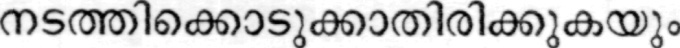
നടത്തിക്കൊടുക്കാതിരിക്കുകയും
